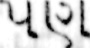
પણ
